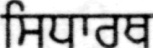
ਸਿਧਾਰਥ
